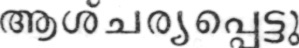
ആശ്ചര്യപ്പെട്ടു
